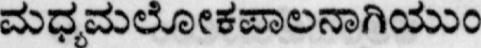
ಮಧ್ಯಮಲೋಕಪಾಲನಾಗಿಯುಂ
